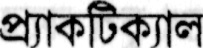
প্র্যাকটিক্যাল
